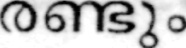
രണ്ടും
